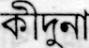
কীদুনা
